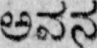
ಅವನ
